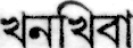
খনখিবা
